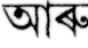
আৰু
